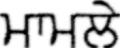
ਮਾਮਲੇ
